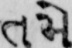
તમે
